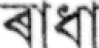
ৰাধা
